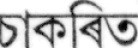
চাকৰিত
